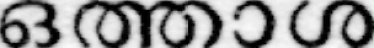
ഒത്താശ
